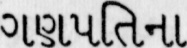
ગણપતિના
